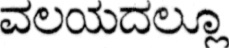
ವಲಯದಲ್ಲೂ
